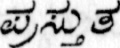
ಪ್ರಸ್ತುತ
